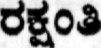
ರಕ್ಷಂತಿ
